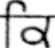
ਕਿ
